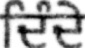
ਦਿੰਦੇ
